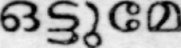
ഒട്ടുമേ
